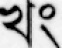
খং
